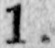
N/Aಚ್ಚ
